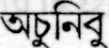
অচুনিবু
